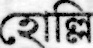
হোল্লি
